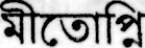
মীতোপ্নি
